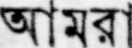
আমরা
